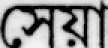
সেয়া
